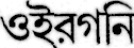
ওইরগনি
